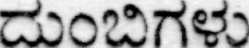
ದುಂಬಿಗಳು
